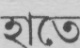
হাতে
